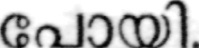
പോയി.
